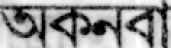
অকনবা
